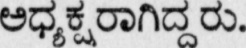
ಅಧ್ಯಕ್ಷರಾಗಿದ್ದರು.
